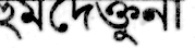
হুমদেক্তুনা
